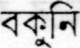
বকুনি
